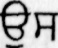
ਉਸ
